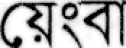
য়েংবা
